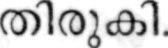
തിരുകി.
